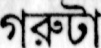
গরুটা
